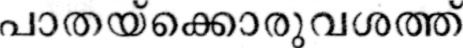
പാതയ്ക്കൊരുവശത്ത്
